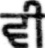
ਵੀ
